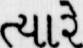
ત્યારે
